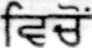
ਵਿਚੋਂ
